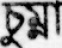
চুম্না
